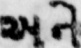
અને
